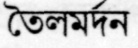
তৈলমর্দন
